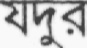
যদুর
